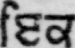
ਇਕ
